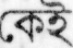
কেই
